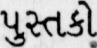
પુસ્તકો
